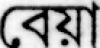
বেয়া
